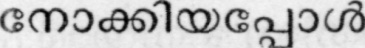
നോക്കിയപ്പോള്‍
